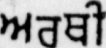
ਅਰਥੀ
